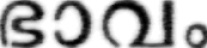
ഭാവം
